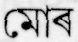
মোৰ
